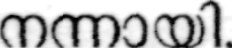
നന്നായി.
